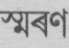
স্মৰণ
